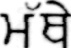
ਮੱਥੇ
